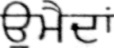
ਉਮੈਦਾਂ
